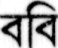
ববি
